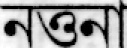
নত্তনা
